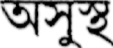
অসুস্থ
